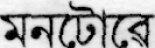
মনটোৱে
